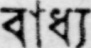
বাধ্য
